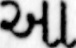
આ
